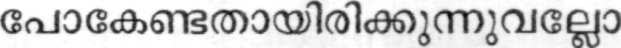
പോകേണ്ടതായിരിക്കുന്നുവല്ലോ
